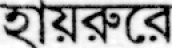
হায়রুরে
